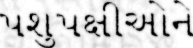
પશુપક્ષીઓને
